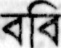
ববি
